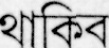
থাকিব
